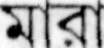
মারা
